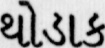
થોડાક
